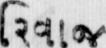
રિવાજ
